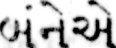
બંનેએ
